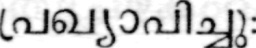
പ്രഖ്യാപിച്ചു:
